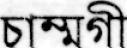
চাম্মগী
